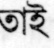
তাই
